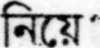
নিয়ে
